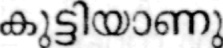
കുട്ടിയാണു
